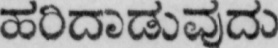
ಹರಿದಾಡುವುದು
